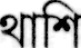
থাশি
